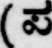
(ಪ
